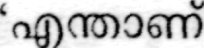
‘എന്താണ്
